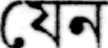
যেন
